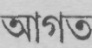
আগত
